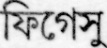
ফিগেসু
